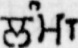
ਲੰਮਾ
